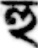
হু
